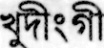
খুদীংগী
